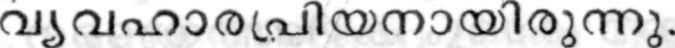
വ്യവഹാരപ്രിയനായിരുന്നു.
